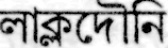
লাক্লদৌনি
